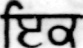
ਇਕ
